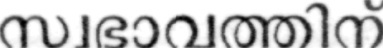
സ്വഭാവത്തിന്
